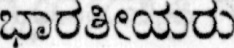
ಭಾರತೀಯರು
